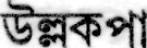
উল্লকপা
